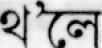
থ'লে
